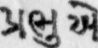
પ્રભુએ
